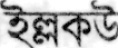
ইল্লকউ
